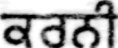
ਕਰਨੀ
